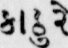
કાઠુરે
